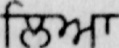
ਲਿਆ
